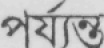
পর্য্যন্ত
